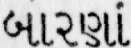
બારણાં
